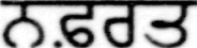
ਨਫ਼ਰਤ
